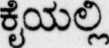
ಕೈಯಲ್ಲಿ
